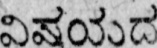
ವಿಷಯದ
